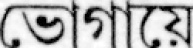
ভোগায়ে
